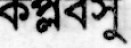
কপ্লবসু
